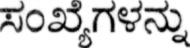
ಸಂಖ್ಯೆಗಳನ್ನು
